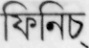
ফিনিচ্
